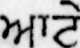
ਆਟੇ
